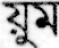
য়ুম
